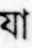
যা
